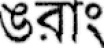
ঙরাং
